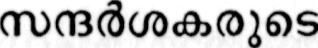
സന്ദര്‍ശകരുടെ
